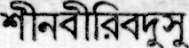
শীনবীরিবদুসু
